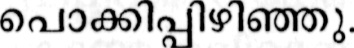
പൊക്കിപ്പിഴിഞ്ഞു.
